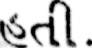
હતી.
